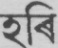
হৰি
